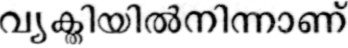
വ്യക്തിയില്‍നിന്നാണ്
